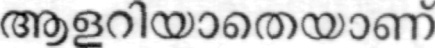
ആളറിയാതെയാണ്
